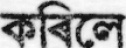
কৰিলে
